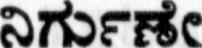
ನಿರ್ಗುಣೇ
